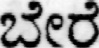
ಬೇರೆ
